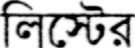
লিস্টের
